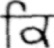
ਕਿ
